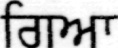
ਗਿਆ
